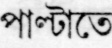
পাল্টাতে
